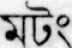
মটং
